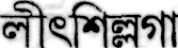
লীৎশিল্লগা
